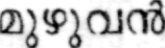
മുഴുവന്‍
